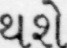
થશે
